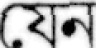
যেন
